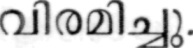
വിരമിച്ചു.
